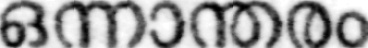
ഒന്നാന്തരം
